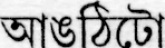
আঙঠিটো
